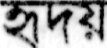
হৃদয়
